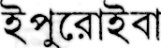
ইপুরোইবা
